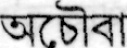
অচৌবা
